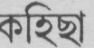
কহিছা
